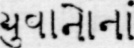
યુવાનોનાં
